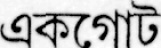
একগোট
